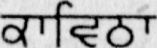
ਕਾਵਿਠਾ
